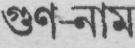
গুণ-নাম
